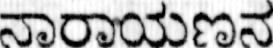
ನಾರಾಯಣನ
